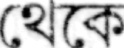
থেকে
